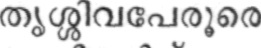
തൃശ്ശിവപേരൂരെ
